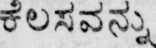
ಕೆಲಸವನ್ನು
